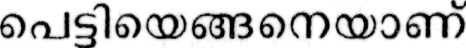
പെട്ടിയെങ്ങനെയാണ്
